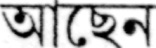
আছেন
